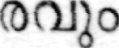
രവും
